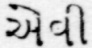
એવી
